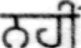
ਨਹੀਂ
